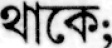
থাকে;
